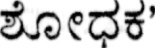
ಶೋಧಕ'
